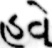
હવે
